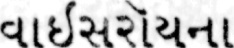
વાઇસરૉયના
